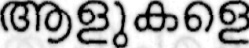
ആളുകളെ
